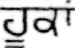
ਹੂਕਾਂ
